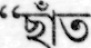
"ছাঁত
